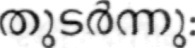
തുടര്‍ന്നു:
